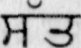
ਸੱਤ
